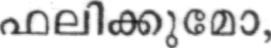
ഫലിക്കുമോ,
